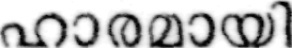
ഹാരമായി
